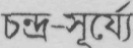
চন্দ্ৰ-সূৰ্য্যে
